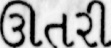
ઊતરી
